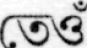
তেওঁ
